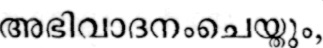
അഭിവാദനംചെയ്തും,
